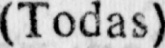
(Todas)
